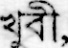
খুবী,
